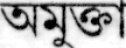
অমুক্তা
